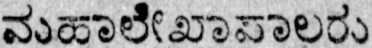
ಮಹಾಲೇಖಾಪಾಲರು
